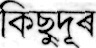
কিছুদূৰ
